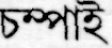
চম্পাই
